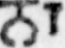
ਨਾ
